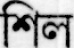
শিল
